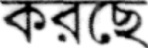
করছে
